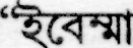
“ইবেম্মা
